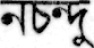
নচন্দু
